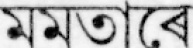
মমতাৰে
